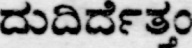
ದುದಿರ್ದೆತ್ತಂ
